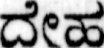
ದೇಹ
